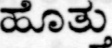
ಹೊತ್ತು
